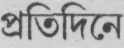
প্ৰতিদিনে
